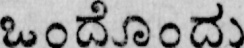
ಒಂದೊಂದು
